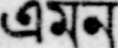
এমন
